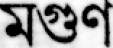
মগুণ
